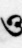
ও
